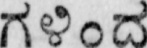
ಗಳಿಂದ
